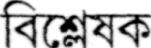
বিশ্লেষক
